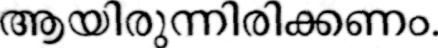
ആയിരുന്നിരിക്കണം.
